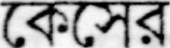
কেসের
